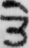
ਤੇ
